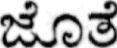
ಜೊತೆ
